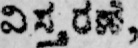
ವಿಸ್ತರಣೆ,
